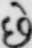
છે
